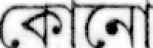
কোনো
